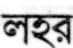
লহর
